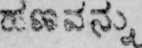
ಹಣವನ್ನು
